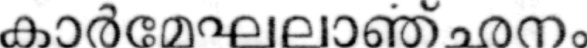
കാര്‍മേഘലാഞ്ഛനം
